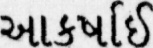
આકર્ષાઈ
